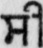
ਸੀ
